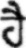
ਹੈ
